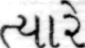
ત્યારે
